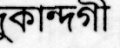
দুকান্দগী
